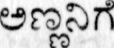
ಅಣ್ಣನಿಗೆ
